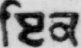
ਇਕ
